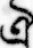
ঐ
